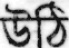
উঠি
